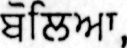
ਬੋਲਿਆ,
